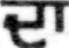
ਦਾ
